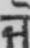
ਜੋ
